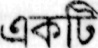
একটি
